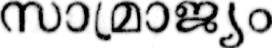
സാമ്രാജ്യം
